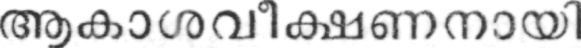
ആകാശവീക്ഷണനായി
